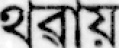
থৱায়
